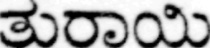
ತುರಾಯಿ
